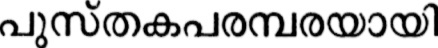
പുസ്തകപരമ്പരയായി
